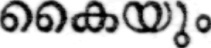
കൈയും
